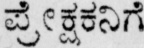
ಪ್ರೇಕ್ಷಕನಿಗೆ
